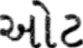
ઓટ
